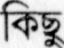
কিছু
